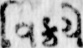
વિક્રયે
